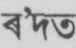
ৰ'দত
